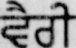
ਵੈਰੀ
